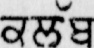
ਕਲੱਬ
